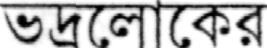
ভদ্রলোকের
